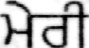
ਮੇਰੀ
